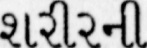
શરીરની
